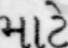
માટે
